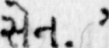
સેન.'
